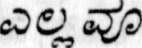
ಎಲ್ಲವೂ
